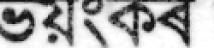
ভয়ংকৰ
